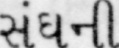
સંઘની
